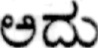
ಅದು
